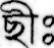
ছীঃ
